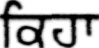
ਕਿਹਾ
